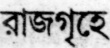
রাজগৃহে
